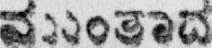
ಮುಂತಾದ
